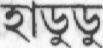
হাডুডু
